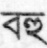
বহু
